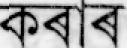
কৰাৰ
